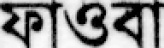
ফাওবা
